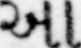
આ
